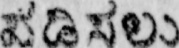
ಪಡಿಸಲು
